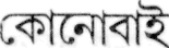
কোনোবাই
